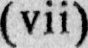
(vii)
